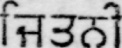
ਜਿਤਨੀ
